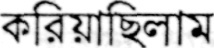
করিয়াছিলাম
